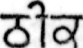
ਠੀਕ
